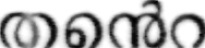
തന്റെ
